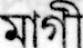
মাগী
